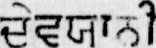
ਦੇਵਯਾਨੀ
